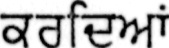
ਕਰਦਿਆਂ
